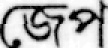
জেপ
